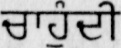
ਚਾਹੁੰਦੀ
